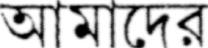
আমাদের
